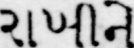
રાખીને
